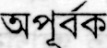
অপূর্বক
